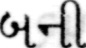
બની
